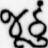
જૂઠું
